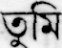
তুমি
